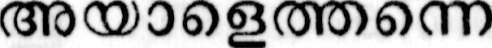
അയാളെത്തന്നെ
